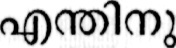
എന്തിനു
